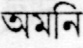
অমনি
